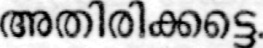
അതിരിക്കട്ടെ.
